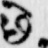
છે.
